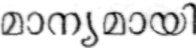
മാന്യമായി
